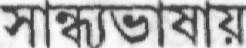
সান্ধ্যভাষায়
